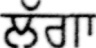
ਲੱਗਾਂ
